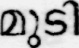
മുടി
